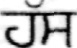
ਹੱਸ
